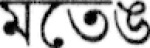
মতেঙ
